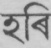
হৰি
